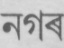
নগৰ
